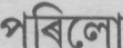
পৰিলো
